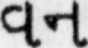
વન
